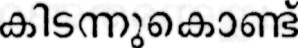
കിടന്നുകൊണ്ട്
